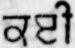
ਕਈ
